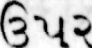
ઉપર
